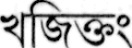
খজিক্তং
